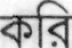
করি
